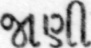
જાણી
